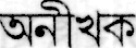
অনীখক
